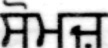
ਸੋਮਜ਼
